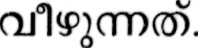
വീഴുന്നത്.
